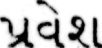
પ્રવેશ
